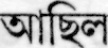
আছিল
